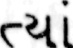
ત્યાં
